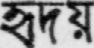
হৃদয়
